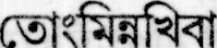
তোংমিন্নখিবা
